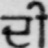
ਦੀ
